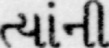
ત્યાંની
